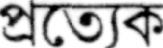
প্রত্যেক
